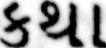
કથા
